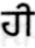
ਹੀ
